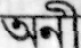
অনী
